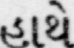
હાથે
